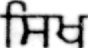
ਸਿਖ
